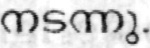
നടന്നു.
